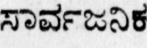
ಸಾರ್ವಜನಿಕ
